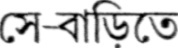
সে-বাড়িতে
